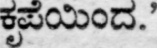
ಕೃಪೆಯಿಂದ.’
